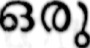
ഒരു
